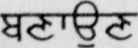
ਬਣਾਉਣ
